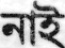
নাই
